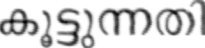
കൂട്ടുന്നതി
